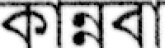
কান্নবা
